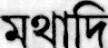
মথাদি
